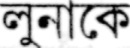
লুনাকে
